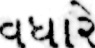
વધારે
